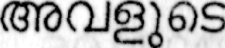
അവളുടെ
